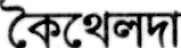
কৈথেলদা
